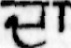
ਦਾ
